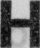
H
